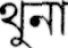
থুনা
